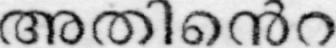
അതിന്റെ
